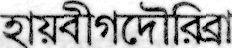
হায়বীগদৌরিব্রা
